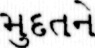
મુદતને
